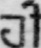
ਹੀ
